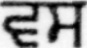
ਵਸ
